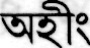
অহীং
